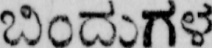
ಬಿಂದುಗಳ
